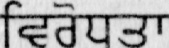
ਵਿਰੋਧਤਾ
